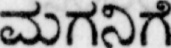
ಮಗನಿಗೆ
